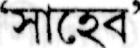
‘সাহেব’
